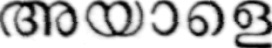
അയാളെ
